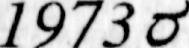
1973ರ
